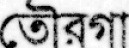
তৌরগা
